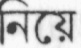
নিয়ে
